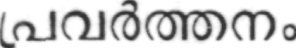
പ്രവര്‍ത്തനം
